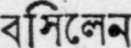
বসিলেন
